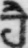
ਹੈ
